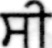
ਸੀ
